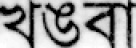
খঙবা
